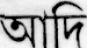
আদি
